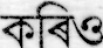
কৰিও
